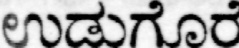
ಉಡುಗೊರೆ
